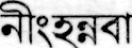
নীংহন্নবা
